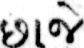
છાજે
